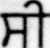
ਸੀ
